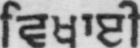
ਵਿਖਾਈ
